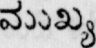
ಮುಖ್ಯ
